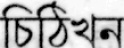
চিঠিখন
